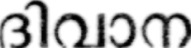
ദിവാന
